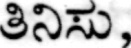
ತಿನಿಸು,
